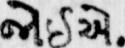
જોઈએ.
